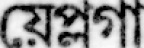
য়েপ্লগা
